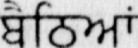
ਬੈਠਿਆਂ
